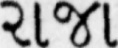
રાજા
